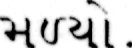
મળ્યો.
